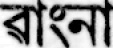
ৱাংনা
